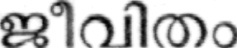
ജീവിതം
